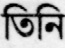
তিনি
